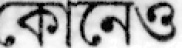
কোনেও
